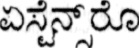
ಏಸ್ಟೆನ್ಸ್ರೊ
